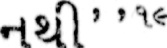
નથી"૧૯
